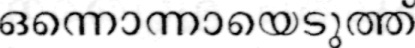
ഒന്നൊന്നായെടുത്ത്
